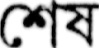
শেষ
